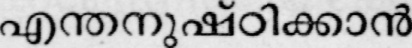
എന്തനുഷ്ഠിക്കാന്‍
